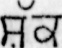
ਸ਼ੱਕ
